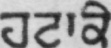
ਹਟਾਕੇ
